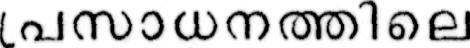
പ്രസാധനത്തിലെ
